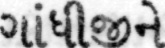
ગાંધીજીને
